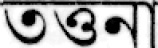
তত্তনা
